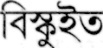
বিস্কুইত
